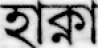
হাক্না
